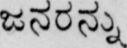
ಜನರನ್ನು
